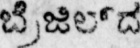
ಬ್ರೆಜಿಲ್ದ
